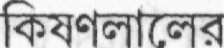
কিষণলালের
